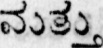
ಮತ್ತು
